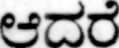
ಆದರೆ
